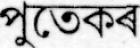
পুতেকৰ
